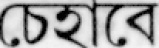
চেহাবে
